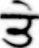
ਤੇ
